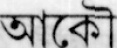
আকৌ
